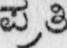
ಪ್ರತಿ
